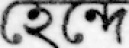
হেন্দে
